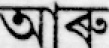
আৰু
